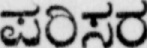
ಪರಿಸರ
